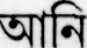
আনি
